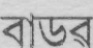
বাড়ৱ
